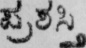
ಪ್ರಶಸ್ತಿ
